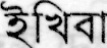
ইখিবা
